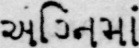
અગ્નિમાં
